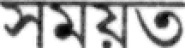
সময়ত
